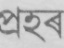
প্ৰহৰ
